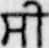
ਸੀ
